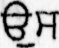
ਉਸ
